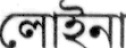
লোইনা
